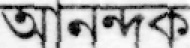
আনন্দক
